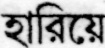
হারিয়ে
